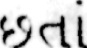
છતાં
